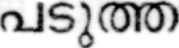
പടുത്ത
